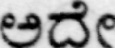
ಅದೇ
